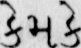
કેમકે
